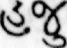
હજુ
